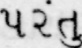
પરંતુ
